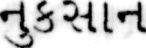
નુકસાન
